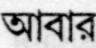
আবার
